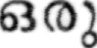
ഒരു
